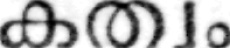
കത്വം
